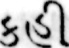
કહી
